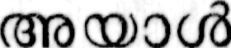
അയാള്‍
